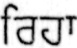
ਰਿਹਾ
